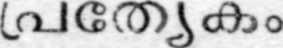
പ്രത്യേകം
